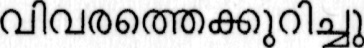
വിവരത്തെക്കുറിച്ചു
